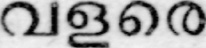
വളരെ
